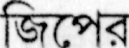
জিপের
